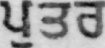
ਪੁਤਰ
